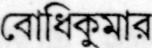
বোধিকুমার
